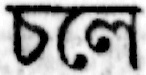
চলে
